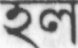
হল
